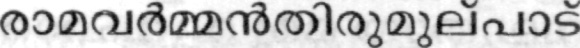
രാമവര്‍മ്മന്‍തിരുമുല്പാട്
